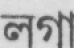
লগা
